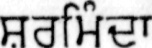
ਸ਼ਰਮਿੰਦਾ
